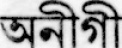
অনীগী
